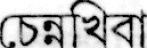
চেন্নখিবা
